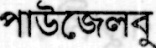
পাউজেলবু
